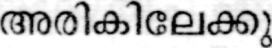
അരികിലേക്കു
